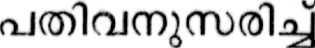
പതിവനുസരിച്ച്
